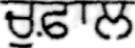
ਚੁਫ਼ਾਲ
